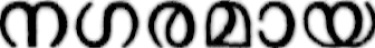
നഗരമായ
